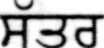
ਸੱਤਰ
